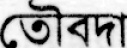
তৌবদা
